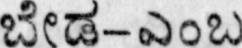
ಬೇಡ-ಎಂಬ
